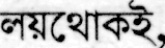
লয়থোকই,
